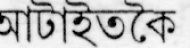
আটাইতকৈ
